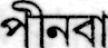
পীনবা
